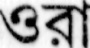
ওরা
